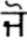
ਜੋ
